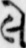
લે
